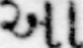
આ
